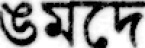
ঙমদে
